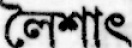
লৈশাৎ
